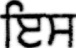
ਇਸ
